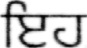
ਇਹ
